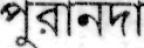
পুরানদা
